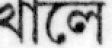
খালে
